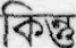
কিন্তু
